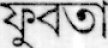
ফুবতা
